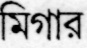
মিগার
